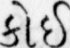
કોઈ
